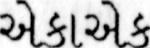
એકાએક
